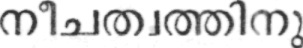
നീചത്വത്തിനു
